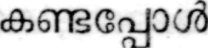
കണ്ടപ്പോള്‍
